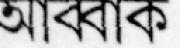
আব্বাক
